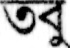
তবু
